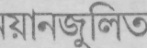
নয়ানজুলিত
